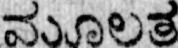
ಮೂಲತ
